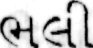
ભલી
